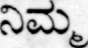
ನಿಮ್ಮ
